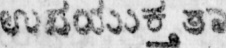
ಉಪಯುಕ್ತತಾ
